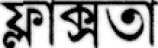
ফ্লাক্সতা
